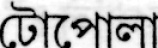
টোপোলা
